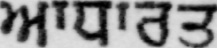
ਆਧਾਰਤ
